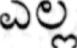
ಎಲ್ಲ
